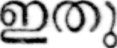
ഇതു
